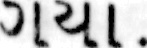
ગયા.
